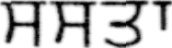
ਸਸਤਾ
